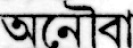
অনৌবা
